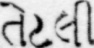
તેટલી
